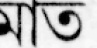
মাত
